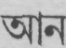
আন
